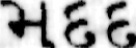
મદદ
